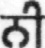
ਨੀ
